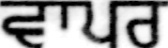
ਵਾਪਰ
